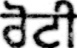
ਰੋਟੀ
